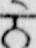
ਨੇ
